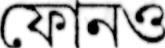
ফোনও
